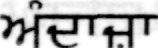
ਅੰਦਾਜ਼ਾ
